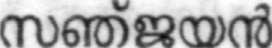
സഞ്ജയന്‍
